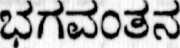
ಭಗವಂತನ
